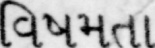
વિષમતા
